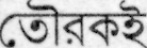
তৌরকই
